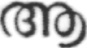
ആ
